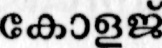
കോളജ്
